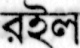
রইল
